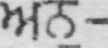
ਅਨੁ-
